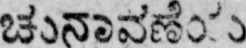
ಚುನಾವಣೆಯ
